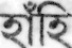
হাঁহি
